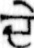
ਦੇ
